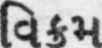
વિક્રમ
